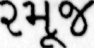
રમૂજ
